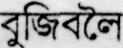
বুজিবলৈ
